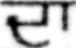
ਦਾ
